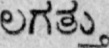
ಲಗತ್ತು
